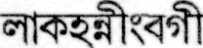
লাকহন্নীংবগী
